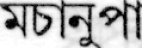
মচানুপা
